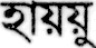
হায়য়ু
